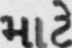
માટે
